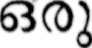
ഒരു
